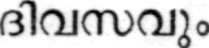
ദിവസവും
